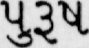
પુરુષ
